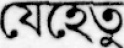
যেহেতু
